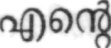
എന്റെ
